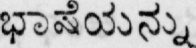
ಭಾಷೆಯನ್ನು
